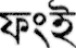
ফংই
